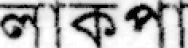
লাকপা
